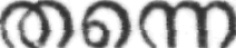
തന്നെ
